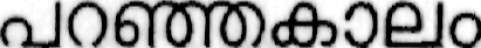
പറഞ്ഞകാലം
